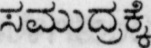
ಸಮುದ್ರಕ್ಕೆ
